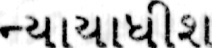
ન્યાયાધીશ
